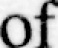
of
